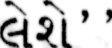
લેશે"
